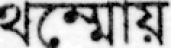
থম্মোয়
